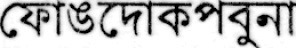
ফোঙদোকপবুনা
